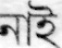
নাই
